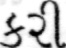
કરી
